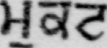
ਮੁਕਟ
